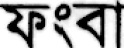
ফংবা
